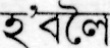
হ'বলৈ
